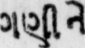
ગણીને
